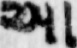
આ
